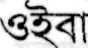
ওইবা
